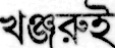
খঞ্জরুই
